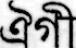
ঐগী
